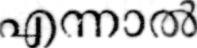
എന്നാല്‍
